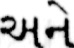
અને
